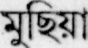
মুছিয়া
